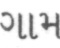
ગામ
